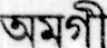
অমগী
